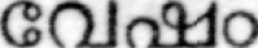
വേഷം
